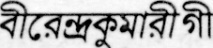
বীরেন্দ্রকুমারীগী
